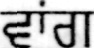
ਵਾਂਗ
